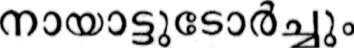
നായാട്ടുടോര്‍ച്ചും
